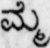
ಮ್ಮೆ
